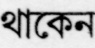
থাকেন
